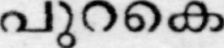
പുറകെ
